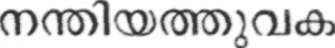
നന്തിയത്തുവക
